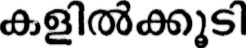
കളില്‍ക്കൂടി
